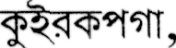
কুইরকপগা,
